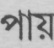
পায়
